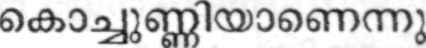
കൊച്ചുണ്ണിയാണെന്നു
